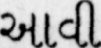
આવી
